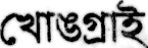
খোঙগ্রাই
